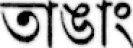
তাঙাং
